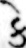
કે
